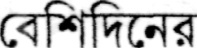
বেশিদিনের
